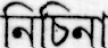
নিচিনা
